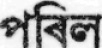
পৰিল
